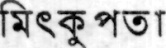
মিৎকুপতা
